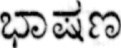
ಭಾಷಣ
